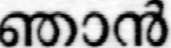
ഞാന്‍
